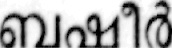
ബഷീര്‍
